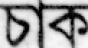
চাক
